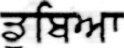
ਡੁਬਿਆ
